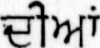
ਦੀਆਂ
